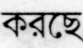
করছে
